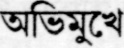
অভিমুখে
